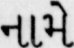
નામે
